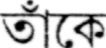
তাঁকে
